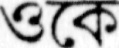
ওকে
